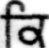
ਕਿ
